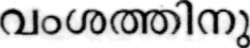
വംശത്തിനു
